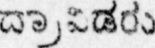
ದ್ರಾವಿಡರು
